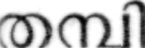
തമ്പി
